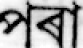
পৰা
